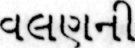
વલણની
